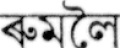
ৰুমলৈ
